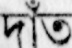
দাঁত
